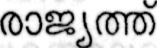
രാജ്യത്ത്
